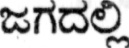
ಜಗದಲ್ಲಿ
